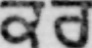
ਕਰ
